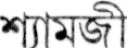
শ্যামজী
